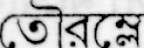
তৌরম্লে
